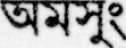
অমসুং
